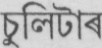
চুলিটাৰ
